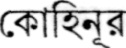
কোহিনূর
